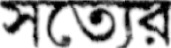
সত্যের
